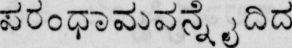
ಪರಂಧಾಮವನ್ನೈದಿದ
